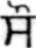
ਸੌ
